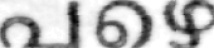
പഴെ
